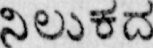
ನಿಲುಕದ
